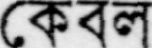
কেবল
